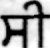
ਸੀ
